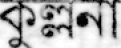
কুল্লনা
